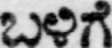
ಬಳಿಗೆ
